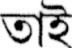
তাই
